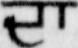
ਦਾ
